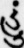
હું
